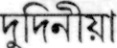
দুদিনীয়া
